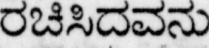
ರಚಿಸಿದವನು
